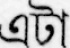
এটা
